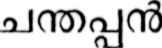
ചന്തപ്പന്‍
